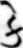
કે
